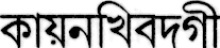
কায়নখিবদগী
